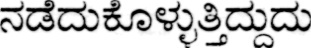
ನಡೆದುಕೊಳ್ಳುತ್ತಿದ್ದುದು
